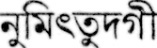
নুমিৎতুদগী
